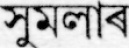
সুমলাৰ
